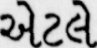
એટલે
